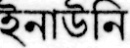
ইনাউনি
